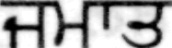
ਜਮਾਤ
